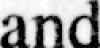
and
